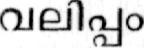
വലിപ്പം
